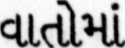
વાતોમાં
